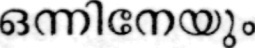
ഒന്നിനേയും
